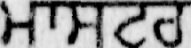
ਮਾਸਟਰ
